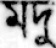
মদু
